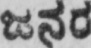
ಜನರ
